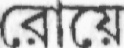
রোয়ে
